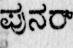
ಪುನರ್
